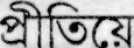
প্রীতিয়ে
